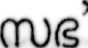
സഭ'
